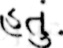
હતું.
